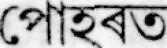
পোহৰত
